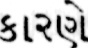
કારણે
